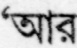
‘আর
